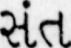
સંત
